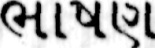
ભાષણ
